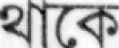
থাকে
